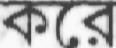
করে
